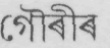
গৌৰীৰ
